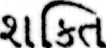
શક્તિ
